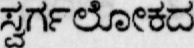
ಸ್ವರ್ಗಲೋಕದ
